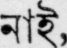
নাই,
